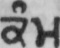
ਕੰਮ
